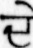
ਦੇ
